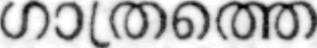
ഗാത്രത്തെ
